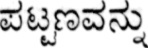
ಪಟ್ಟಣವನ್ನು
